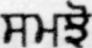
ਸਮਝੋ
